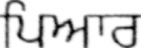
ਪਿਆਰ
